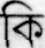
কি
